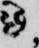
છે,
